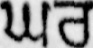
ਘਰ
